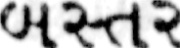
બસ્તર
